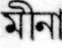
মীনা
